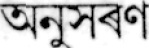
অনুসৰণ
